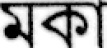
মকা
